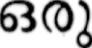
ഒരു
